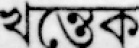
খন্তেক
